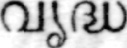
വൃദ്ധ
